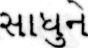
સાધુને
